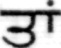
ਤਾਂ
